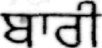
ਬਾਰੀ
